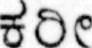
ಕರೀ
